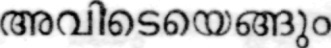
അവിടെയെങ്ങും
